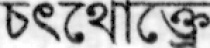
চৎথোক্ত্রে
